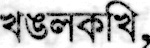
খঙলকখি,
